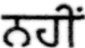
ਨਹੀਂ
